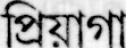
প্রিয়াগা
